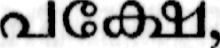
പക്ഷേ,
